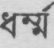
ধৰ্ম্ম
